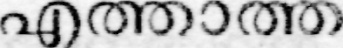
എത്താത്ത
